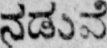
ನಡುವೆ
